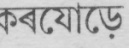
কৰযোড়ে
